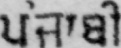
ਪੰਜਾਬੀ
